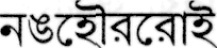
নঙহৌররোই
